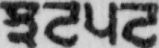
ਝਟਪਟ
